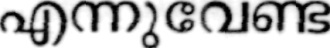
എന്നുവേണ്ട
